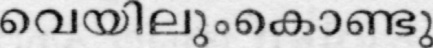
വെയിലുംകൊണ്ടു
